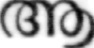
ആ
